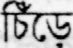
চিঁড়ে
